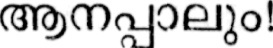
ആനപ്പാലും!
